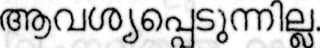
ആവശ്യപ്പെടുന്നില്ല.
